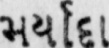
મર્યાદા
